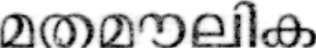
മതമൌലിക
